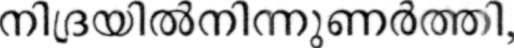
നിദ്രയില്‍നിന്നുണര്‍ത്തി,
